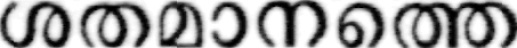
ശതമാനത്തെ
